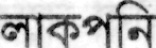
লাকপনি
